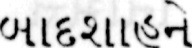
બાદશાહને
